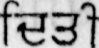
ਦਿਤੀ
